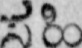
ಸಹಿ
